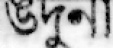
ঙদুনা
